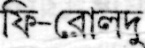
ফি-রোলদু
